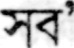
সব’
